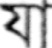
যা
